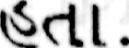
હતા.
